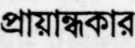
প্রায়ান্ধকার
